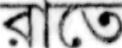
রাতে
